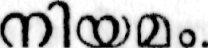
നിയമം.
